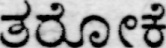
ತರೋಕೆ
